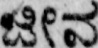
ಜೀವ
